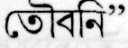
তৌবনি”
